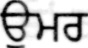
ਉਮਰ
